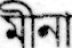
মীনা
